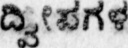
ದ್ವೀಪಗಳ
